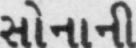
સોનાની
